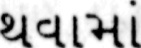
થવામાં
